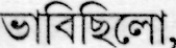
ভাবিছিলো,
